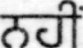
ਨਹੀਂ
